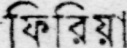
ফিরিয়া
